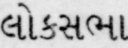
લોકસભા
